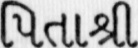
પિતાશ્રી
